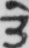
ਤੇ
